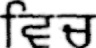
ਵਿਚ
